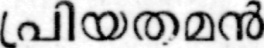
പ്രിയതമന്‍
